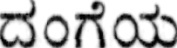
ದಂಗೆಯ
